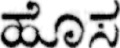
ಹೊಸ
